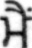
ਮੈਂ
